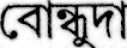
বোন্ধুদা
